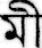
মী
